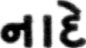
નાદે
